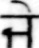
ਜੇ
